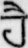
ਹੈ
